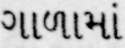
ગાળામાં
